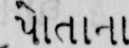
પોતાના
